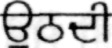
ਉਠਦੀ
